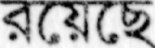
রয়েছে
